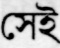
সেই
